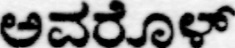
ಅವರೊಳ್
